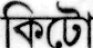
কিটো
